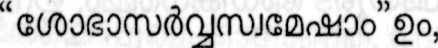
''ശോഭാസര്‍വ്വസ്വമേഷാം"ഉം,
